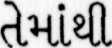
તેમાંથી
